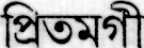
প্রিতমগী
